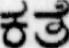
ಕತೆ
